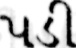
પડી
